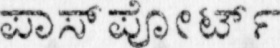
ಪಾಸ್‌ಪೋರ್ಟ್
